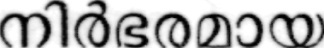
നിര്‍ഭരമായ
